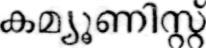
കമ്യൂണിസ്റ്റ്
